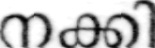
നക്കി
